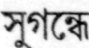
সুগন্ধে
